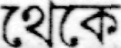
থেকে
